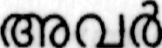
അവര്‍
